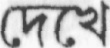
দেখে
